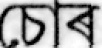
চোৰ
